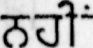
ਨਹੀਂ
